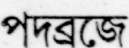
পদব্রজে
